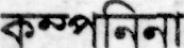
কম্পনিনা
